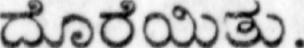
ದೊರೆಯಿತು.
